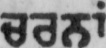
ਚਰਨਾਂ
